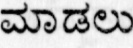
ಮಾಡಲು
